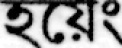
হয়েং
